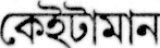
কেইটামান
